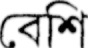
বেশি
